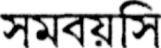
সমবয়সি
